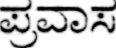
ಪ್ರವಾಸ
